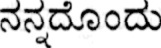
ನನ್ನದೊಂದು
